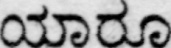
ಯಾರೂ
